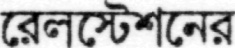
রেলস্টেশনের
